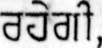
ਰਹੇਗੀ,
